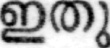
ഇതു
